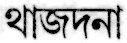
থাজদনা
